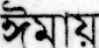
ঈমায়
